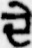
ਦੇ
